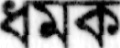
ধমক
